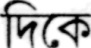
দিকে
